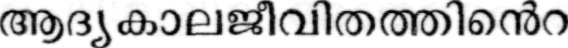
ആദ്യകാലജീവിതത്തിന്റെ
